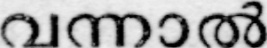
വന്നാല്‍
